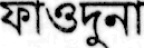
ফাওদুনা
